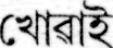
খোৱাই
